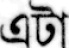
এটা
